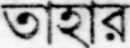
তাহার
